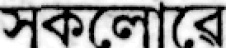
সকলোৱে
